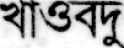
খাওবদু
